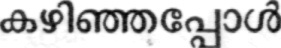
കഴിഞ്ഞപ്പോള്‍
